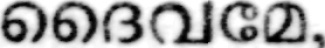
ദൈവമേ,
